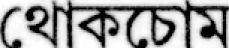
থোকচোম
